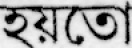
হয়তো
